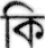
কি
